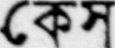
কেস
